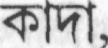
কাদা,
